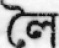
লৈ
